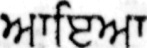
ਆਇਆ
